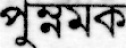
পুম্নমক
